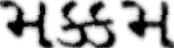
મક્કમ
